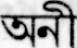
অনী
